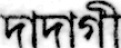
দাদাগী
